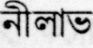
নীলাভ
